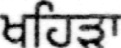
ਖਹਿੜਾ
